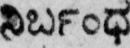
ನಿರ್ಬಂಧ
